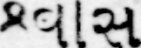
શ્વાસ
